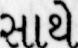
સાથે
